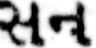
સન
